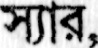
স্যার,
